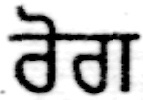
ਰੋਗ
